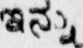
ಇನ್ನು
